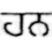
ਹਨ
